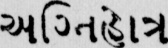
અગ્નિહોત્ર
